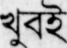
খুবই
